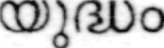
യുദ്ധം
